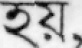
হয়,
